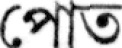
পোত
